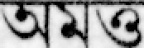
অমত্ত
